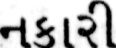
નકારી
